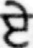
ਏ
